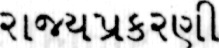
રાજ્યપ્રકરણી
